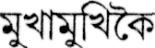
মুখামুখিকৈ
